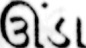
ઊંડા
